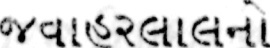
જવાહરલાલનો
